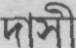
দাসী
